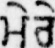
ਮੇਰੇ
